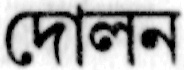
দোলন
